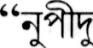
“নুপীদু
